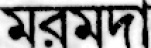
মরমদা
